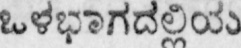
ಒಳಭಾಗದಲ್ಲಿಯ
